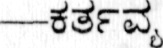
-ಕರ್ತವ್ಯ
